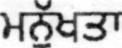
ਮਨੁੱਖਤਾ
